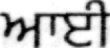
ਆਈ
